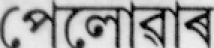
পেলোৱাৰ
